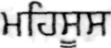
ਮਹਿਸੂਸ
